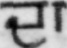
ਦਾ
